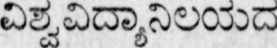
ವಿಶ್ವವಿದ್ಯಾನಿಲಯದ
